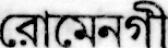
রোমেনগী
